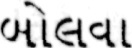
બોલવા
